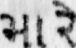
મારે
